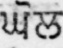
ਘੋਲ
